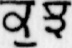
ਕੁਝ
